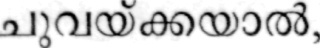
ചുവയ്ക്കയാല്‍,
